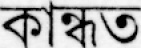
কান্ধত
